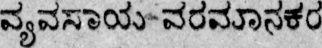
ವ್ಯವಸಾಯ-ವರಮಾನಕರ
